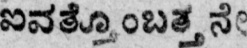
ಐವತ್ತೊಂಬತ್ತನೇ
